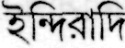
ইন্দিরাদি
